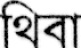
থিবা
